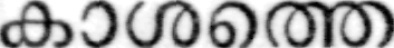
കാശത്തെ
